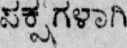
ಪಕ್ಷಗಳಾಗಿ
